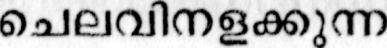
ചെലവിനളക്കുന്ന
